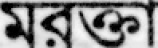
মরক্তা
